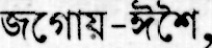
জগোয়-ঈশৈ,
